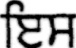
ਇਸ
